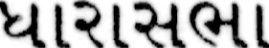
ધારાસભા
